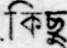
কিছু
